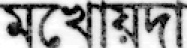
মখোয়দা
